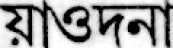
য়াওদনা
